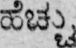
ಹೆಚ್ಚು
